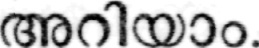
അറിയാം.
